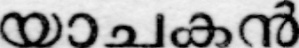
യാചകന്‍
